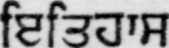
ਇਤਿਹਾਸ
